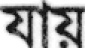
যায়
